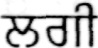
ਲਗੀ
